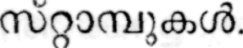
സ്റ്റാമ്പുകള്‍.
